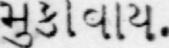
મુકાવાય.
